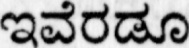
ಇವೆರಡೂ
